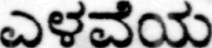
ಎಳವೆಯ
